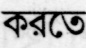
করতে
